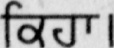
ਕਿਹਾ।
